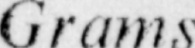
Grams
